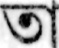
তা
